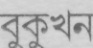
বুকুখন
